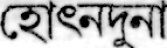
হোৎনদুনা
